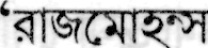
‘রাজমোহন্স
